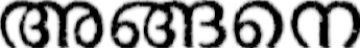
അങ്ങനെ
